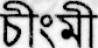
চীংমী
